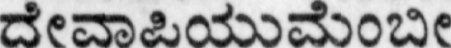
ದೇವಾಪಿಯುಮೆಂಬೀ
